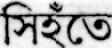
সিহঁতে
